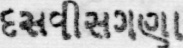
દસવીસગણા
